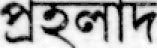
প্রহলাদ
